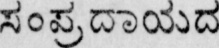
ಸಂಪ್ರದಾಯದ
